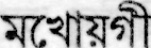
মখোয়গী
